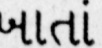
ખાતાં
